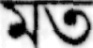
মত
